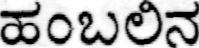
ಹಂಬಲಿನ
